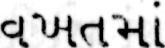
વખતમાં
